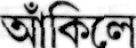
আঁকিলে
